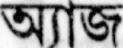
অ্যাজ
